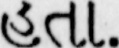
હતા
